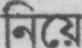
নিয়ে
